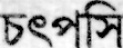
চৎপসি
